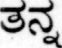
ತನ್ನ
